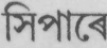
সিপাৰে
